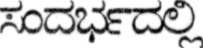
ಸಂದರ್ಭದಲ್ಲಿ
